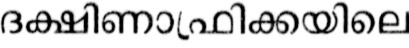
ദക്ഷിണാഫ്രിക്കയിലെ
